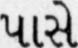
પાસે
